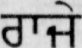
ਰਾਜੇ
